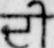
ਦੀ
